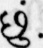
છું.
